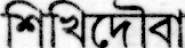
শিখিদৌবা
